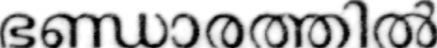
ഭണ്ഡാരത്തില്‍
